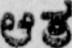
ಆತ
